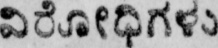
ವಿರೋಧಿಗಳು
